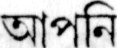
আপনি
